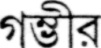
গম্ভীর
